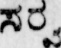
ಸರ್ವ
